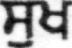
ਸੁਖ
